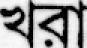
খরা
